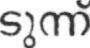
ടുന്ന്
